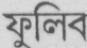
ফুলিব
